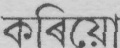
কৰিয়ো
